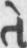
તે
